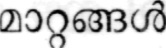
മാറ്റങ്ങള്‍
